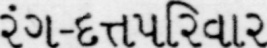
રંગ-દત્તપરિવાર
